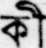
কী
